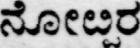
ನೋೞ್ಪರ
